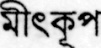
মীৎকূপ
